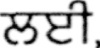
ਲਈ,
